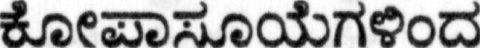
ಕೋಪಾಸೂಯೆಗಳಿಂದ
